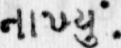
નાખ્યું.
